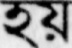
হয়
